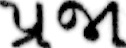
પ્રજા
